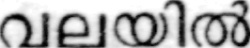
വലയില്‍
